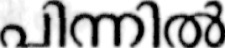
പിന്നില്‍
